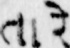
તારે
